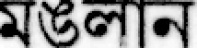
মঙলান
